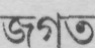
জগত
